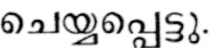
ചെയ്യപ്പെട്ടു.
